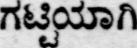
ಗಟ್ಟಿಯಾಗಿ
